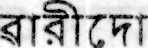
ৱারীদো
